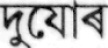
দুযোৰ
